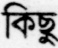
কিছু
